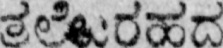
ತಲೆಬರಹದ
